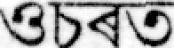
ওচৰত
